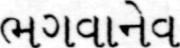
ભગવાનેવ
